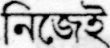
নিজেই
